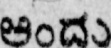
ಅಂದು
